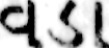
વડા
